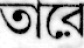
তারে
